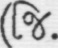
(જિ.
